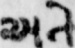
અને
